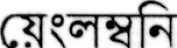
য়েংলম্বনি
